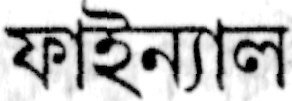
ফাইন্যাল
